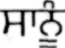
ਸਾਨੂੰ
